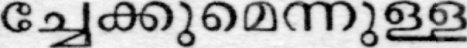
ച്ചേക്കുമെന്നുള്ള
